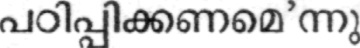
പഠിപ്പിക്കണമെ’ന്നു
